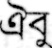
ঐবু
